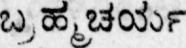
ಬ್ರಹ್ಮಚರ್ಯ
